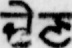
ਦੇਣ
